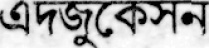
এদজুকেসন
